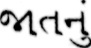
જાતનું
